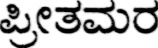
ಪ್ರೀತಮರ
